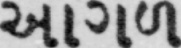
આગળ
